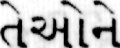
તેઓને
